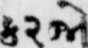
કરજો
